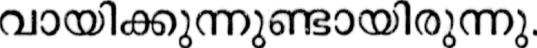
വായിക്കുന്നുണ്ടായിരുന്നു.
